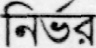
নির্ভর
